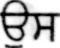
ਉਸ
